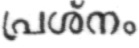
പ്രശ്നം
